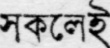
সকলেই
